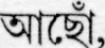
আছোঁ,
